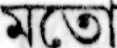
মতো
